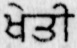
ਖੇਤੀ
